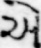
એ
